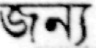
জন্য
